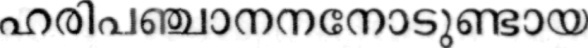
ഹരിപഞ്ചാനനനോടുണ്ടായ
